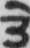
ਤੇ
